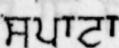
ਸਪਾਟਾ
